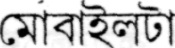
মোবাইলটা
